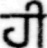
ਹੀ
